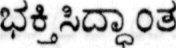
ಭಕ್ತಿಸಿದ್ಧಾಂತ
